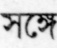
সঙ্গে
